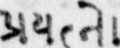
પ્રયત્નો
